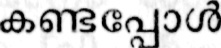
കണ്ടപ്പോള്‍
